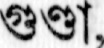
গুণ্ডা,
